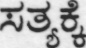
ಸತ್ಯಕ್ಕೆ
